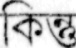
কিন্তু
